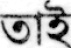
তাই
